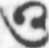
ও
